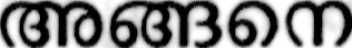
അങ്ങനെ
